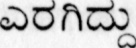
ಎರಗಿದ್ದು
